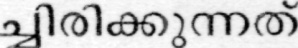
ച്ചിരിക്കുന്നത്
